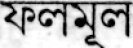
ফলমূল
